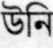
উনি
